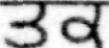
ਤਕ
